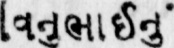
વિનુભાઈનું
